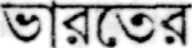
ভারতের
